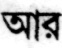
আর
